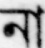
না
